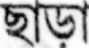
ছাড়া
